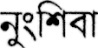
নুংশিবা
